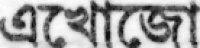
এখোজো
